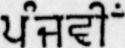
ਪੰਜਵੀਂ
